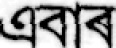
এবাৰ
